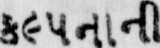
કલ્પનાની
